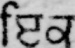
ਇਕ
